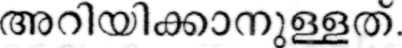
അറിയിക്കാനുള്ളത്.
